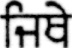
ਜਿਥੇ
